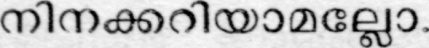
നിനക്കറിയാമല്ലോ.
